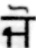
ਜੋ
